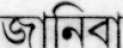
জানিবা
